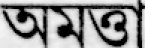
অমত্তা
